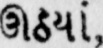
ઊઠ્યાં,
